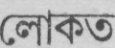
লোকত
